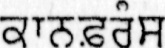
ਕਾਨਫ਼ਰੰਸ
